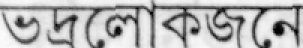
ভদ্রলোকজনে
